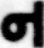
ન
